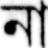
না
